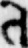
તે
